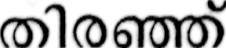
തിരഞ്ഞ്
